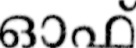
ഓഫ്
